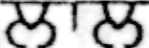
ਲਾਲ
